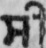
ਸੀ
